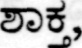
ಶಾಕ್ತ,
